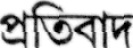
প্রতিবাদ
